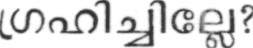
ഗ്രഹിച്ചില്ലേ?
